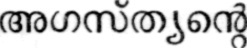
അഗസ്ത്യന്റെ
